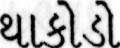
થાકોડો
